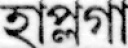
হাপ্লগা
